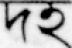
দহ
